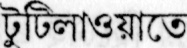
টুটিলাওয়াতে
